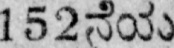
152ನೆಯ
